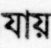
যায়
